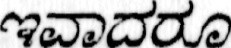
ಇವಾದರೂ
